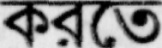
করতে
